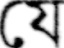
যে
